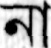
না
